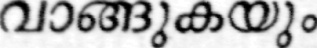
വാങ്ങുകയും
